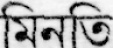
মিনতি
